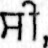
ਸੀ,
